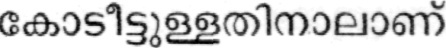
കോടീട്ടുള്ളതിനാലാണ്
